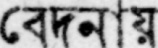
বেদনায়
